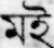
মই
